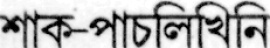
শাক-পাচলিখিনি
